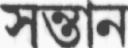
সন্তান
